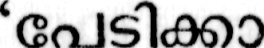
‘പേടിക്കാ
